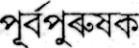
পূর্বপুৰুষক
